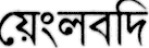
য়েংলবদি
